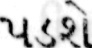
પડશે
